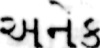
અનેક
